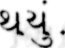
થયું.
